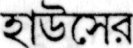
হাউসের
